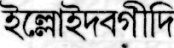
ইল্লোইদবগীদি
